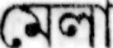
মেলা
